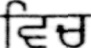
ਵਿਚ
